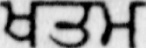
ਖਤਮ
